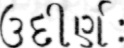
ઉદીર્ણઃ
